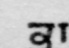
ਭਾ
